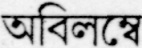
অবিলম্বে
